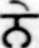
ਨੇ
